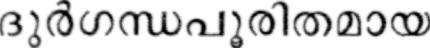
ദുര്‍ഗന്ധപൂരിതമായ
